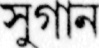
সুগান
